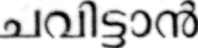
ചവിട്ടാന്‍
